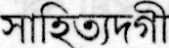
সাহিত্যদগী
